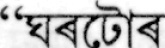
"ঘৰটোৰ
